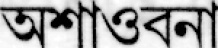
অশাওবনা
